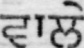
ਵਾਲੇ
